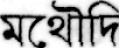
মথৌদি
